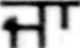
ਜਾ
